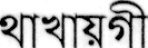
থাখায়গী
